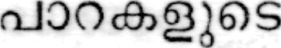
പാറകളുടെ
